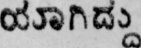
ಯಾಗಿದ್ದು
